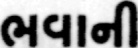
ભવાની
